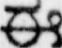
ಈ
